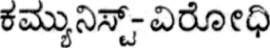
ಕಮ್ಯುನಿಸ್ಟ್-ವಿರೋಧಿ
